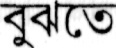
বুঝতে
